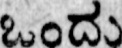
ಒಂದು
